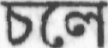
চলে
